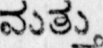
ಮತ್ತು
